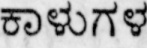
ಕಾಳುಗಳ
